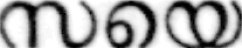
സയെ
